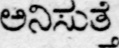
ಅನಿಸುತ್ತೆ
